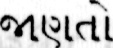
જાણતો
